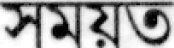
সময়ত
